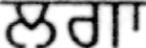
ਲਗਾ
